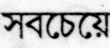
সবচেয়ে
